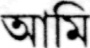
আমি
